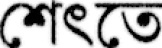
শেৎতে
